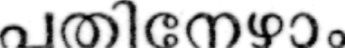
പതിനേഴാം
